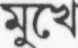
মুখে
